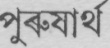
পুৰুষাৰ্থ
